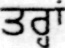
ਤਰ੍ਹਾਂ
